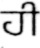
ਹੀ
